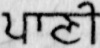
ਪਾਣੀ
